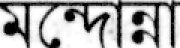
মন্দোন্না
